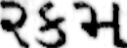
રકમ
